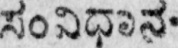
ಸಂವಿಧಾನ.
